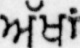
ਅੱਖਾਂ
